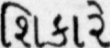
શિકારે
